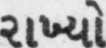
રાખ્યો
